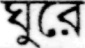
ঘুরে
